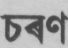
চৰণ
